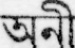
অনী
